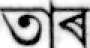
তাৰ
